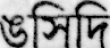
ঙসিদি
